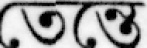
তেন্তে
